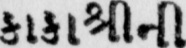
કાકાશ્રીની
